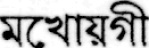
মখোয়গী
